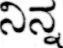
ನಿನ್ನ
